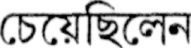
চেয়েছিলেন
